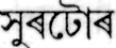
সুৰটোৰ
